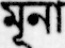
মূনা
